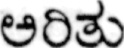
ಅರಿತು
